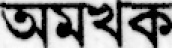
অমখক
